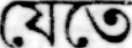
যেতে
